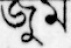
জুম
